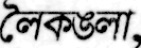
লৈকঙলা,
